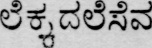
ಲೆಕ್ಕದಲೆಸೆವ
